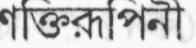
শক্তিরূপিনী
